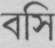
বসি
